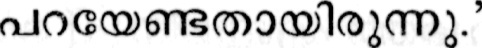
പറയേണ്ടതായിരുന്നു.’
